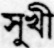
সুখী
